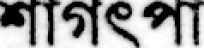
শাগৎপা
